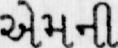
એમની
